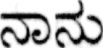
ನಾನು
